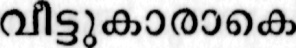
വീട്ടുകാരാകെ
